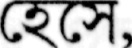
হেসে,
